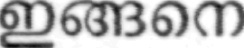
ഇങ്ങനെ
